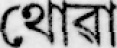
থোৱা
